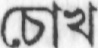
চোখ
